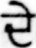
ਦੇ
